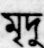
মৃদু
